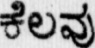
ಕೆಲವು
